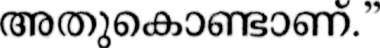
അതുകൊണ്ടാണ്.”
